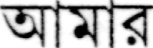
আমার
